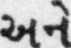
અને
